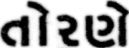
તોરણે
